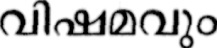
വിഷമവും
